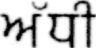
ਅੱਧੀ
